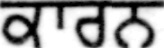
ਕਾਰਨ
